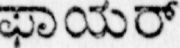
ಫಾಯರ್
